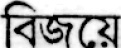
বিজয়ে
